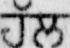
ਹੱਲ
